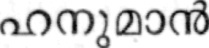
ഹനുമാന്‍
